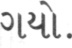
ગયો.
